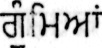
ਗੁੰਮਿਆਂ
